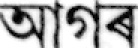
আগৰ
